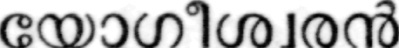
യോഗീശ്വരന്‍
